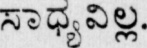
ಸಾಧ್ಯವಿಲ್ಲ.
